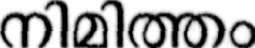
നിമിത്തം
